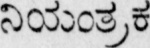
ನಿಯಂತ್ರಕ
